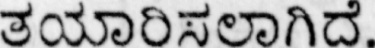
ತಯಾರಿಸಲಾಗಿದೆ.
